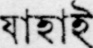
যাহাই
